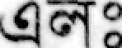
এলঃ
